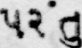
પરંતુ
